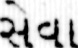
સેવા
